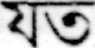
যত
